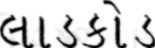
લાડકોડ
